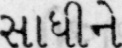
સાધીને
